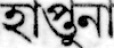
হাপ্তুনা
